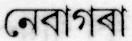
নেবাগৰা
